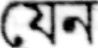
যেন
